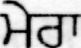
ਮੇਰਾ
